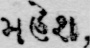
મહેશ,
